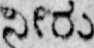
ನೀರು
